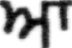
ਆ
